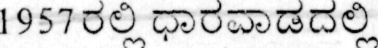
1957ರಲ್ಲಿಧಾರವಾಡದಲ್ಲಿ
